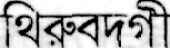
থিরুবদগী
